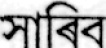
সাৰিব
